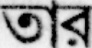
তার
